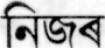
নিজৰ
